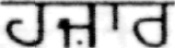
ਹਜ਼ਾਰ
